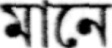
মানে
